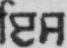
ਇਸ
